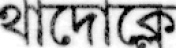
থাদোক্লে
